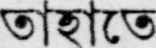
তাহাতে
